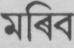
মৰিব
